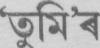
'তুমি'ৰ
